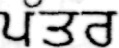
ਪੱਤਰ
